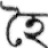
হৈ
